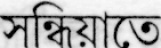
সন্ধিয়াতে
